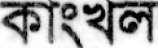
কাংখল
